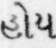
હોય
